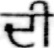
ਦੀ
